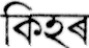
কিহৰ
